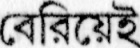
বেরিয়েই
